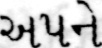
અપને
